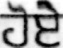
ਹੋਏ
